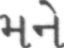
મને
